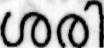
ശരി
